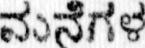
ಮನೆಗಳ
